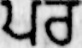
ਪਰ
